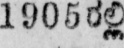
1905ರಲ್ಲಿ
